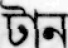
টান
